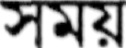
সময়
